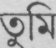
তুমি
